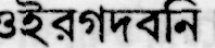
ওইরগদবনি
